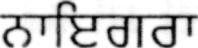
ਨਾਇਗਰਾ
